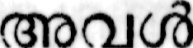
അവള്‍
